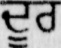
ਦੂਰ
